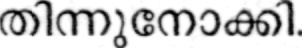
തിന്നുനോക്കി.
